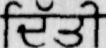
ਦਿੱਤੀ
